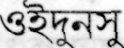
ওইদুনসু
